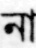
না
